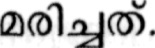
മരിച്ചത്.
